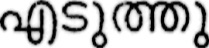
എടുത്തു
